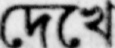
দেখে
